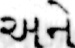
અને
